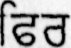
ਫਿਰ
